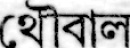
থৌবাল
